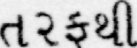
તરફથી
